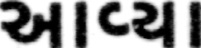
આવ્યા
